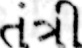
તંત્રી
